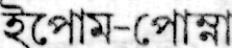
ইপোম-পোম্না
